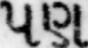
પણ
